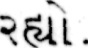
રહ્યો.
